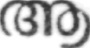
ആ
